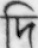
দি
